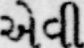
એવી
